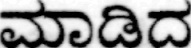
ಮಾಡಿದ
